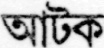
আটক
